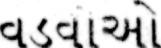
વડવાઓ
